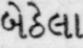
બેઠેલા
